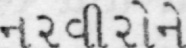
નરવીરોને
